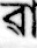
ৱা
